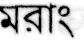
মরাং
